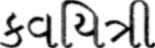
કવયિત્રી
